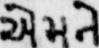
એમને
